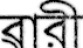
ৱারী
